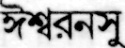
ঈশ্বরনসু
